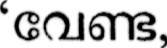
'വേണ്ട,
